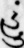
હું
